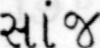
સાંજ
